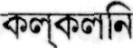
কলকলনি
